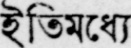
ইতিমধ্যে
